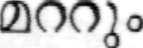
മററും
